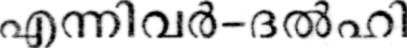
എന്നിവര്‍-ദല്‍ഹി
